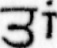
ਤਾਂ
